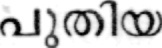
പുതിയ
